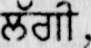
ਲੱਗੀ,
